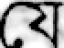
যে
